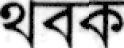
থবক
